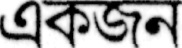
একজন
